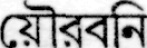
য়ৌরবনি
